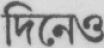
দিনেও
